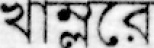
খাম্লরে
